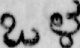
ಒಳ
